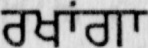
ਰਖਾਂਗਾ
